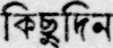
কিছুদিন
